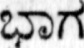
ಭಾಗ
